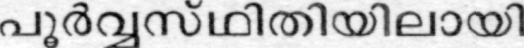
പൂര്‍വ്വസ്ഥിതിയിലായി
